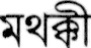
মথক্ককী
